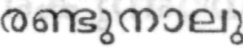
രണ്ടുനാലു
